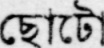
ছোটো
